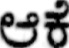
ಆಕೆ
